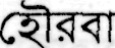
হৌরবা
